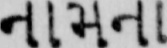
નામના
